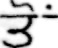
ਤੋਂ
